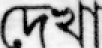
দেখা
